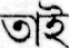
তাই
